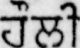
ਹੌਲੀ
